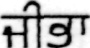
ਜੀਭਾ
